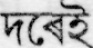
দৰেই
